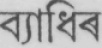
ব্যাধিৰ
